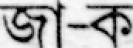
জা-ক
